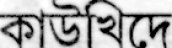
কাউখিদে
